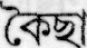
কৈছা
